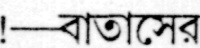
!—বাতাসের
